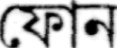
ফোন
